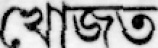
খোজত
